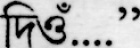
দিওঁ...."
